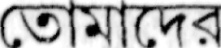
তোমাদের
